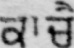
ਕਾਚੈ
